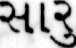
સારુ
